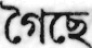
গৈছে
